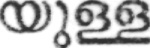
യുള്ള
